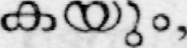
കയും,
